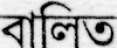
বালিত
